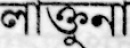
লাক্তুনা
